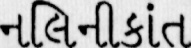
નલિનીકાંત
